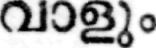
വാളും
